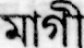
মী
